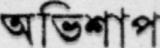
অভিশাপ
